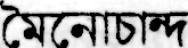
মৈনোচান্দ
